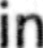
in
